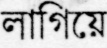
লাগিয়ে
